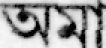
অমা
